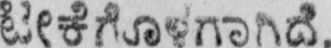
ಟೀಕೆಗೊಳಗಾಗಿದೆ.
